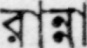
রান্না
